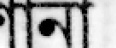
লানা
